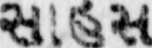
સાહસ
